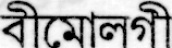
বীমোলগী
